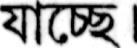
যাচ্ছে।
